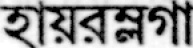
হায়রম্লগা
